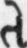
તે
